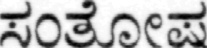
ಸಂತೋಷ
